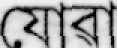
যোৱা
